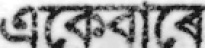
একেবাৰে
